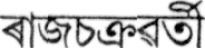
ৰাজচক্রৱর্তী
